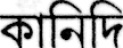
কানিদি
